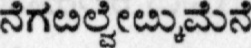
ನೆಗೞಲ್ವೇೞ್ಕುಮೆನೆ
